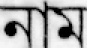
নাম
